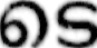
ടെ
